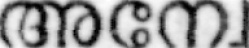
അന്വേ
